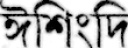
ঈশিংদি
